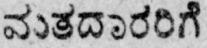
ಮತದಾರರಿಗೆ
